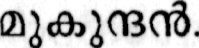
മുകുന്ദന്‍.
